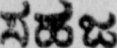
ಸಹಜ
